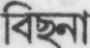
বিছনা
